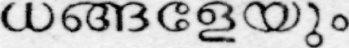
ധങ്ങളേയും
